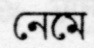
নেমে
